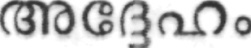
അദ്ദേഹം
